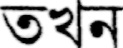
তখন
